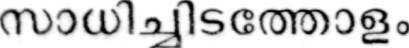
സാധിച്ചിടത്തോളം
